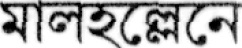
মালহল্লেনে
